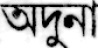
অদুনা
